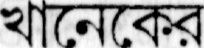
খানেকের
